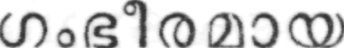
ഗംഭീരമായ
